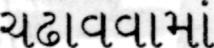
ચઢાવવામાં
